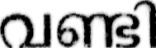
വണ്ടി
